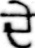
ਦੇ
